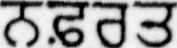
ਨਫ਼ਰਤ
